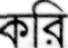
করি
